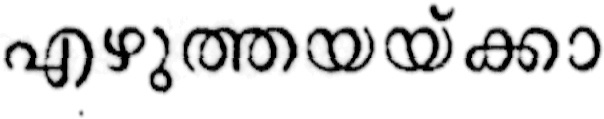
എഴുത്തയയ്ക്കാ
